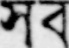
সব
